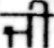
ਜੀ
